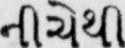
નીચેથી
